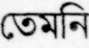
তেমনি
